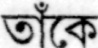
তাঁকে
